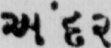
અંદર
